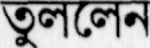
তুললেন
